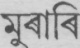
মুৰাৰি
